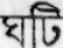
ঘটি
